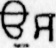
ਉਸ
